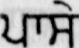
ਪਾਸੇ
